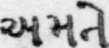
અમને
